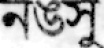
নঙসু
